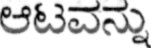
ಆಟವನ್ನು
